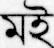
মই
